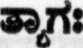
ತ್ಯಾಗಃ
